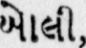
બોલી,
